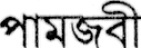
পামজবী
